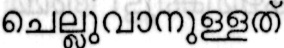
ചെല്ലുവാനുള്ളത്.
